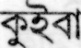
কুইবা
